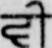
ਵੀ
